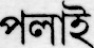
পলাই
